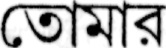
তোমার
